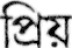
প্রিয়
